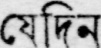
যেদিন
